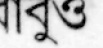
বাবুও
